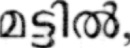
മട്ടില്‍,
